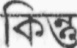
কিন্তু
